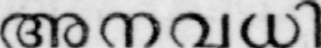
അനവധി
